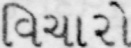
વિચારો
